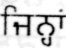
ਜਿਨ੍ਹਾਂ
